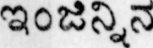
ಇಂಜಿನ್ನಿನ
